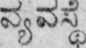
ವ್ಯವಸ್ಥೆ
